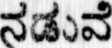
ನಡುವೆ
